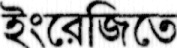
ইংরেজিতে
